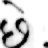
છે
